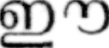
ഈ
